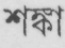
শঙ্কা
